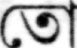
তো
